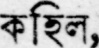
কহিল,
